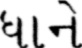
ધાને
